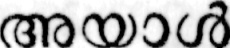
അയാള്‍
